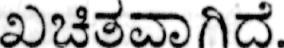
ಖಚಿತವಾಗಿದೆ.
